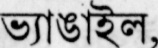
ভ্যাঙাইল,
